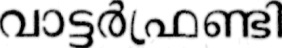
വാട്ടര്‍ഫ്രണ്ടി
